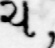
ચ,
